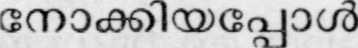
നോക്കിയപ്പോള്‍
